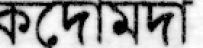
কদোমদা
